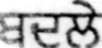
ਬਦਲੇ
